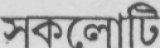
সকলোটি
